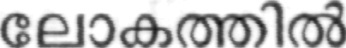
ലോകത്തില്‍
